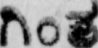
ಗಿಂತ
